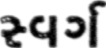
સ્વર્ગ
